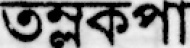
তম্লকপা
